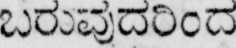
ಬರುವುದರಿಂದ
